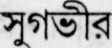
সুগভীর
